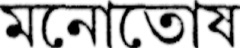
মনোতোষ
